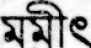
মমীৎ
